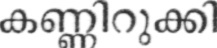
കണ്ണിറുക്കി
